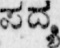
ಪದ್ಯ
